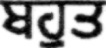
ਬਹੁਤ
